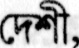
দেশী,
